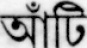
আঁটি
